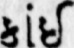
કાંઈ
